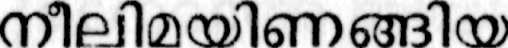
നീലിമയിണങ്ങിയ
